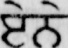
ਏਨੇ
